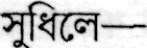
সুধিলে-
